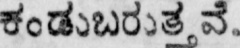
ಕಂಡುಬರುತ್ತವೆ.
